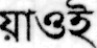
য়াওই
